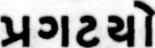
પ્રગટ્યો
